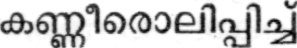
കണ്ണീരൊലിപ്പിച്ച്
